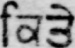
ਕਿਤੇ
